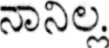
ನಾನಿಲ್ಲ.
